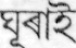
ঘূৰাই
